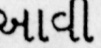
આવી
